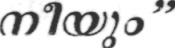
നീയും"
